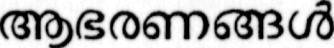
ആഭരണങ്ങള്‍
